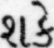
શકે
